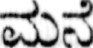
ಮನೆ
